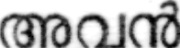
അവന്‍
